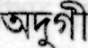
অদুগী
